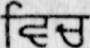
ਵਿਚ
